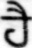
ਹੈ
